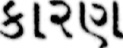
કારણ
